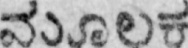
ಮೂಲಕ
